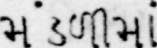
મંડળીમાં
